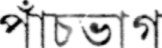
পাঁচভাগ
